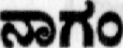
ನಾಗಂ
